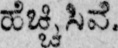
ಹೆಚ್ಚಿಸಿವೆ.
